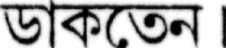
ডাকতেন।
